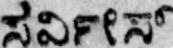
ಸರ್ವೀಸ್
